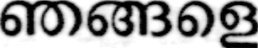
ഞങ്ങളെ
